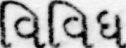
વિવિધ
